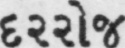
દરરોજ
